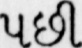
પછી
